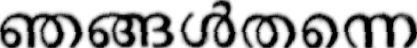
ഞങ്ങള്‍തന്നെ
